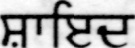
ਸ਼ਾਇਦ
